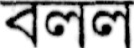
বলল
